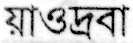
য়াওদ্রবা
